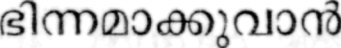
ഭിന്നമാക്കുവാന്‍
